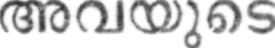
അവയുടെ
